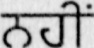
ਨਹੀਂ
